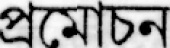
প্ৰমোচন
